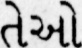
તેઓ
